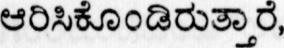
ಆರಿಸಿಕೊಂಡಿರುತ್ತಾರೆ,
